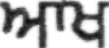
ਆਖ
